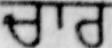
ਚਾਰ
